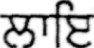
ਲਾਇ
